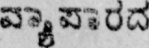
ವ್ಯಾಪಾರದ
